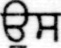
ਉਸ
